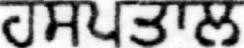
ਹਸਪਤਾਲ
